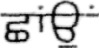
ਛਾਂਉ
